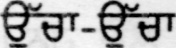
ਉੱਚਾ-ਉੱਚਾ
